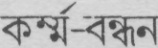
কৰ্ম্ম-বন্ধন
